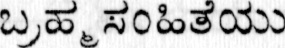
ಬ್ರಹ್ಮಸಂಹಿತೆಯು
